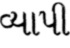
વ્યાપી
